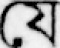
যে
